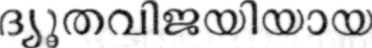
ദ്യൂതവിജയിയായ
